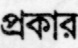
প্রকার
